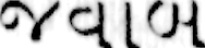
જવાબ
